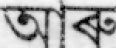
আৰু
